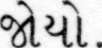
જોયો.
